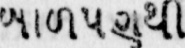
બાળપણથી
